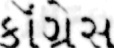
કૉંગ્રેસ
